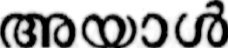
അയാള്‍
